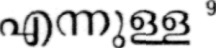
എന്നുള്ള9
